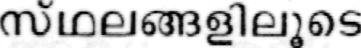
സ്ഥലങ്ങളിലൂടെ
